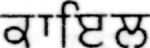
ਕਾਇਲ
